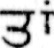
ਤਾਂ
